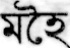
মহৈ
